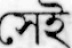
সেই
